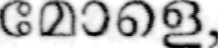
മോളെ,
